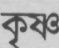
কৃষ্ণ
